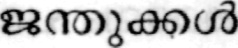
ജന്തുക്കള്‍
